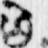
છે.
